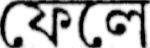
ফেলে
